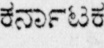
ಕರ್ನಾಟಕ
